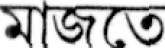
মাজতে
